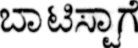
ಬಾಟಿಸ್ಟಾಗೆ
